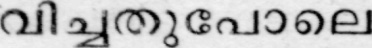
വിച്ചതുപോലെ
